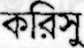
করিসু
